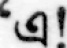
‘এ!
